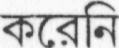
করেনি
